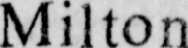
Milton
